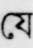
যে
